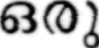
ഒരു
